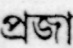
প্রজা
